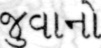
જુવાનો
